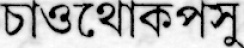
চাওথোকপসু
